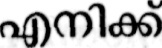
എനിക്ക്
